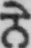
ਨੇ
